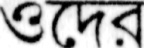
ওদের
